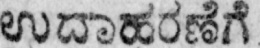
ಉದಾಹರಣೆಗೆ
